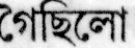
গৈছিলো
